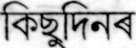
কিছুদিনৰ
